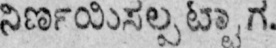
ನಿರ್ಣಯಿಸಲ್ಪಟ್ಟಾಗ.
